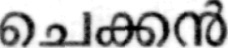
ചെക്കന്‍
